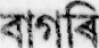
বাগৰি
